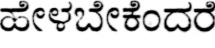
ಹೇಳಬೇಕೆಂದರೆ
